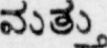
ಮತ್ತು
